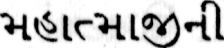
મહાત્માજીની
